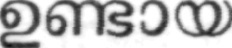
ഉണ്ടായ
